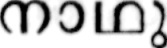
നാഥു
